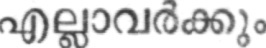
എല്ലാവര്‍ക്കും
